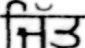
ਜਿੱਤ
